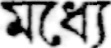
মধ্যে
